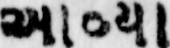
આવ્યા
